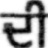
ਦੀ
